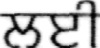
ਲਈ
